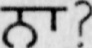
ਨਾ?
